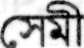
সেমী
